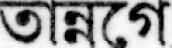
তান্নগে
